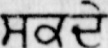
ਸਕਦੇ
